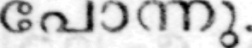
പോന്നു.
